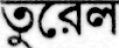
তুরেল
